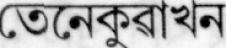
তেনেকুৱাখন
